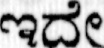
ಇದೇ
